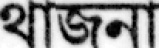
থাজনা
